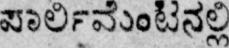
ಪಾರ್ಲಿಮೆಂಟಿನಲ್ಲಿ
